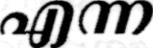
എന്ന
